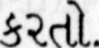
કરતો.
